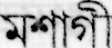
মশাগী
